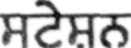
ਸਟੇਸ਼ਨ
